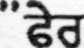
''ਫੇਰ
